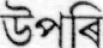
উপৰি
